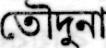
তৌদুনা
